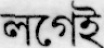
লগেই
